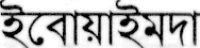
ইবোয়াইমদা
